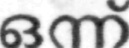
ഒന്ന്
